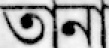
তানা
